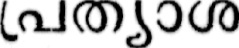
പ്രത്യാശ
